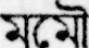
মমৌ
